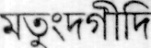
মতুংদগীদি
